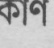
কাণ
